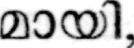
മായി,
